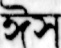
ঈস
